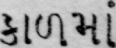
કાળમાં
